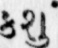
કશું
